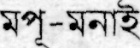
মপূ-মনাই
